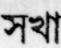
সখা
